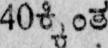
40ಕ್ಕಿಂತ
